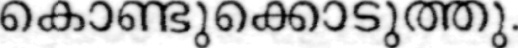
കൊണ്ടുക്കൊടുത്തു.
